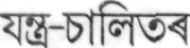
যন্ত্র-চালিতৰ
